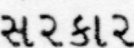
સરકાર
